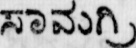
ಸಾಮಗ್ರಿ
